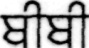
ਬੀਬੀ
